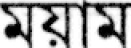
ময়াম
